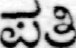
ಪತಿ
